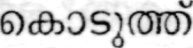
കൊടുത്ത്
